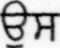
ਉਸ
